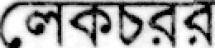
লেকচরর
